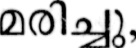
മരിച്ചു,
